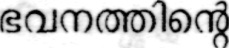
ഭവനത്തിന്റെ
